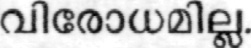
വിരോധമില്ല.
